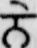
ਨੇ
